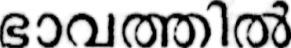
ഭാവത്തില്‍
